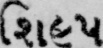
શિલ્પ
